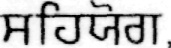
ਸਹਿਯੋਗ,
